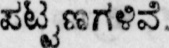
ಪಟ್ಟಣಗಳಿವೆ.
